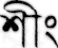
শীং
